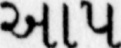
આપ
